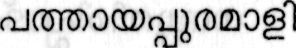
പത്തായപ്പുരമാളി
